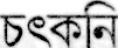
চৎকনি
